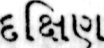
દક્ષિણ
